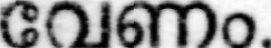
വേണം.
